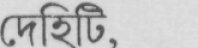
দেহিটি,
